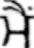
ਮੈਂ
